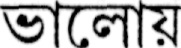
ভালোয়
